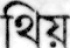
থিয়
